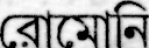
রোমোনি
